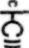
ਨੂੰ
